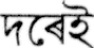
দৰেই
